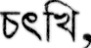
চৎখি,
